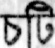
চটি
